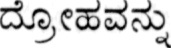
ದ್ರೋಹವನ್ನು
